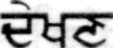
ਦੇਖਣ
